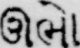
ઊભો
